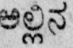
ಅಲ್ಲಿನ
